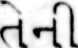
તેની
